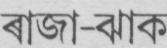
ৰাজা-ঝাক
